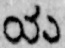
ಯ
